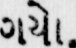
ગયો.
